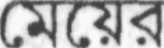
মেয়ের
